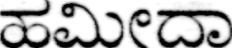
ಹಮೀದಾ
